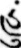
હું
